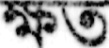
ক্ষত
